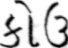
કોઉ
